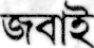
জবাই
